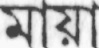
মায়া
